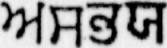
ਅਸਭਯ
